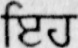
ਇਹ
